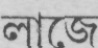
লাজে
